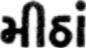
મીઠાં
